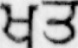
ਖਤ
